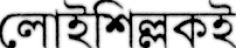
লোইশিল্লকই
